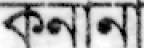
কনানা
